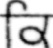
ਕਿ
